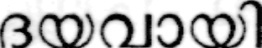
ദയവായി
